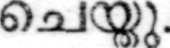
ചെയ്തു.
